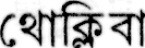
থোক্লিবা
